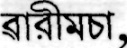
ৱারীমচা,
